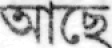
আছে
